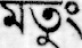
মতুং
